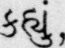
કહ્યું,
